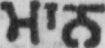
ਮਾਨ
